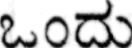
ಒಂದು
